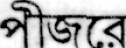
পীজরে
